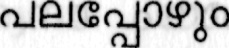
പലപ്പോഴും
